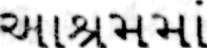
આશ્રમમાં
